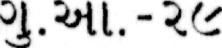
ગુ.આ.-૨૯
